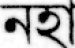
নহা
